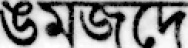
ঙমজদে
